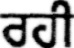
ਰਹੀ
